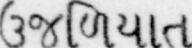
ઉજળિયાત
